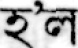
হ'ল
